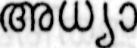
അധ്യാ
